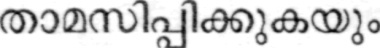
താമസിപ്പിക്കുകയും
